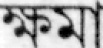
ক্ষমা
